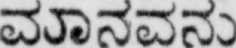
ಮಾನವನು
